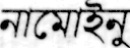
নামোইনু
